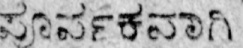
ಪೂರ್ವಕವಾಗಿ
